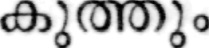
കുത്തും
